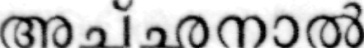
അച്ഛനാല്‍
